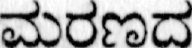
ಮರಣದ
